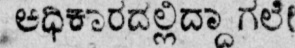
ಅಧಿಕಾರದಲ್ಲಿದ್ದಾಗಲೇ
